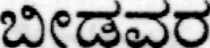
ಬೀಡವರ
